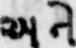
અને
